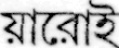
য়ারোই
